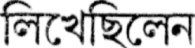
লিখেছিলেন
